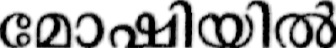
മോഷിയില്‍
